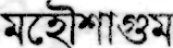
মহৌশাগুম
